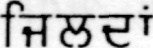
ਜਿਲਦਾਂ
